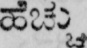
ಹೆಚ್ಚು
